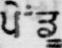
ਪੇਂਡੂ
